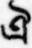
ঐ
